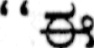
"ಈ
